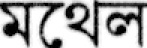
মথেল
